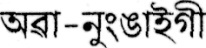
অৱা-নুংঙাইগী
